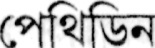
পেথিডিন
